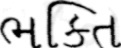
ભક્તિ
